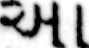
આ
